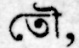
তৌ,
